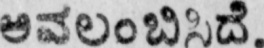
ಅವಲಂಬಿಸಿದೆ.
